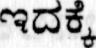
ಇದಕ್ಕೆ
